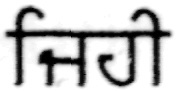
ਜਿਹੀ
